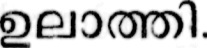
ഉലാത്തി.
